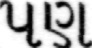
પણ
